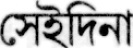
সেইদিনা
